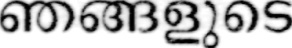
ഞങ്ങളുടെ
